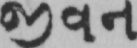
જીવન
